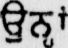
ਉਨ੍ਹਾਂ
